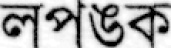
লপঙক
